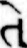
તે
